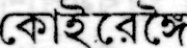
কোইরেঙ্গৈ
